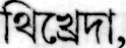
থিখ্রেদা,
